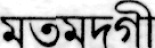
মতমদগী
